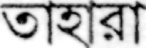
তাহারা
